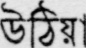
উঠিয়া
